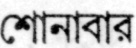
শোনাবার
